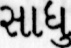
સાધુ
